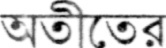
অতীতের
